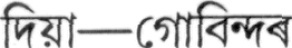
দিয়া-গোবিন্দৰ
